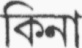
কিনা
